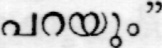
പറയും”
